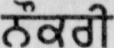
ਨੌਕਰੀ
